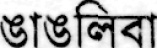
ঙাঙলিবা
